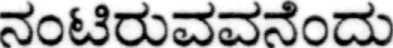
ನಂಟಿರುವವನೆಂದು
